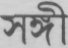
সঙ্গী
